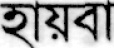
হায়বা
